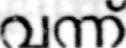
വന്ന്
